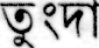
তুংদা
